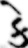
કે
